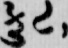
કુટ,
